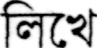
লিখে
